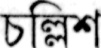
চল্লিশ
